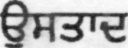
ਉਸਤਾਦ
